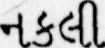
નકલી
